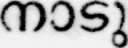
നാടു
